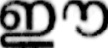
ഈ
